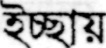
ইচ্ছায়
